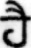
ਹੈ
